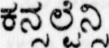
ಕನ್ಸಲ್ಟೆನ್ಸಿ
